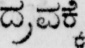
ದ್ರವಕ್ಕೆ
